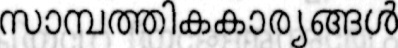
സാമ്പത്തികകാര്യങ്ങള്‍
